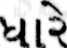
ધારે
